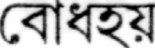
বোধহয়
